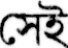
সেই
